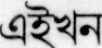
এইখন
